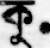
কু.
